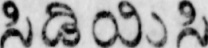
ಸಿಡಿಯಿಸಿ
